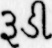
રૂડી
